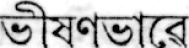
ভীষণভাৱে
